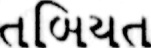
તબિયત
